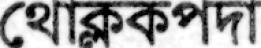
থোক্লকপদা
